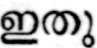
ഇതു
